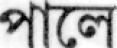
পালে
